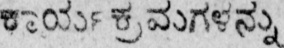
ಕಾರ್ಯಕ್ರಮಗಳನ್ನು
